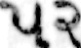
પર
